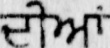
ਦੀਆਂ
